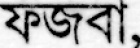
ফজবা,
